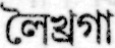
লৈখ্রগা
